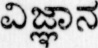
ವಿಜ್ಞಾನ
